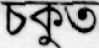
চকুত
